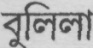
বুলিলা
